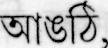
আঙঠি,
